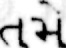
તમે
